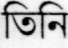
তিনি
